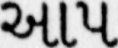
આપ
